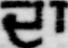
ਦਾ
